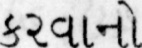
કરવાનો
